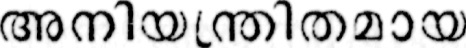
അനിയന്ത്രിതമായ
